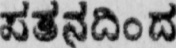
ಪತನದಿಂದ
